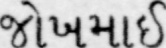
જોખમાઈ
